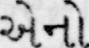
એનો
